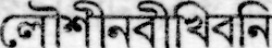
লৌশীনবীখিবনি
